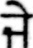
ਜੇ
